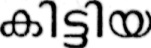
കിട്ടിയ
